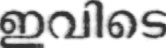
ഇവിടെ
